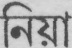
নিয়া
